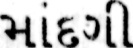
માંદગી
